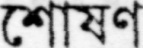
শোষণ
